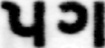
પગ
